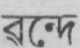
ৱন্দে
